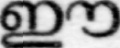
ഈ
